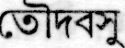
তৌদবসু
